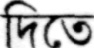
দিতে
